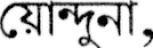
য়োন্দুনা,
